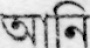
আনি
